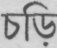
চড়ি
